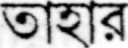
তাহার
